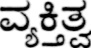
ವ್ಯಕ್ತಿತ್ವ
